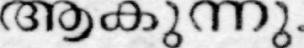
ആകുന്നു.
